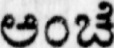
ಅಂಚೆ
